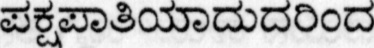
ಪಕ್ಷಪಾತಿಯಾದುದರಿಂದ
